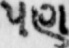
પણ
